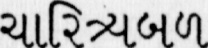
ચારિત્ર્યબળ
